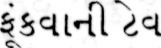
કૂંકવાનીટેવ
